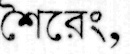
শৈরেং,
